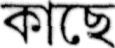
কাছে
